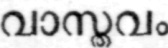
വാസ്തവം
